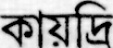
কায়দ্রি
